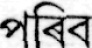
পৰিব
